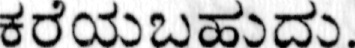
ಕರೆಯಬಹುದು.
